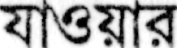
যাওয়ার
